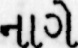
નાગે
